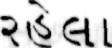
રહેલા
